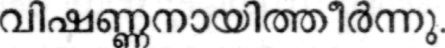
വിഷണ്ണനായിത്തീര്‍ന്നു.
